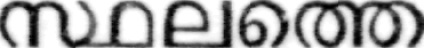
സ്ഥലത്തെ
